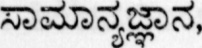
ಸಾಮಾನ್ಯಜ್ಞಾನ,
